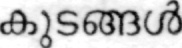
കുടങ്ങള്‍
